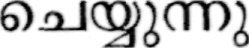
ചെയ്യുന്നു
